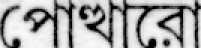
পোত্থারো
